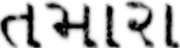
તમારા
